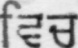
ਵਿਚ
